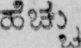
ಹೆಚ್ಚು
